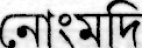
নোংমদি
